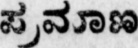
ಪ್ರಮಾಣ
